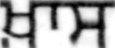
ਖ਼ਾਸ
